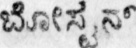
ಬೋಸ್ಟನ್
